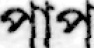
পাপ
